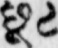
છૂટ
